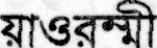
য়াওরম্মী
